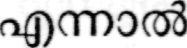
എന്നാല്‍
